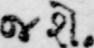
જશે.
